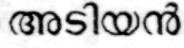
അടിയന്‍
